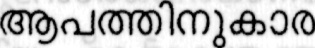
ആപത്തിനുകാര
